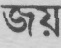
জয়
